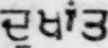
ਦੁਖਾਂਤ
